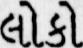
લોકો
